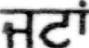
ਜਟਾਂ
